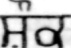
ਸ਼ੌਕ
